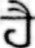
ਹੈ
